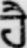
ਹੈ
